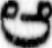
ಆ
